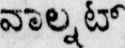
ವಾಲ್ನಟ್
